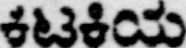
ಕಿಟಕಿಯ
